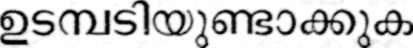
ഉടമ്പടിയുണ്ടാക്കുക
